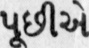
પૂછીએ
